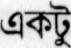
একটু
